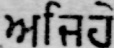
ਅਜਿਹੇ
